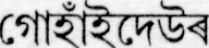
গোহাঁইদেউৰ
